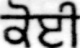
ਕੋਈ
